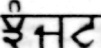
ਝੰਜਟ
